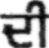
ਦੀ
